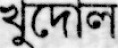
খুদোল
